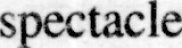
spectacle
